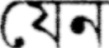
যেন
